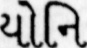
યોનિ
